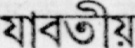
যাবতীয়
